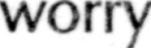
worry
